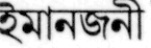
ইমানজনী
